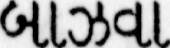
બાઝવા
